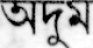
অদুম
